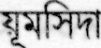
য়ূমসিদা
